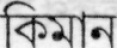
কিমান
